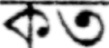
কত
